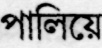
পালিয়ে
